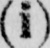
(i)
